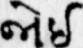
જોઈ
